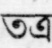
তত্র
